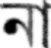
না
